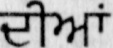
ਦੀਆਂ
